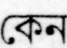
কেন
